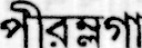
পীরম্লগা
